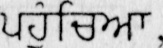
ਪਹੁੰਚਿਆ,
